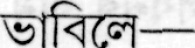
ভাবিলে-
